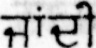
ਜਾਂਦੀ
